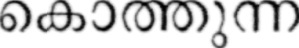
കൊത്തുന്ന
